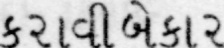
કરાવીબેકાર
